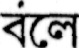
বলে
